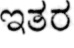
ಇತರ
